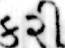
કરી
